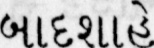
બાદશાહે
